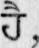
ਹੈ,
